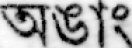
অঙাং
